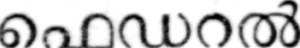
ഫെഡറല്‍
